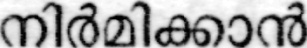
നിര്‍മിക്കാന്‍
